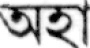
অহা
